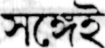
সঙ্গেই
